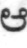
ಆ
